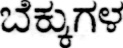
ಬೆಕ್ಕುಗಳ
